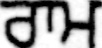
ਰਾਮ
